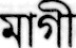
মাগী
